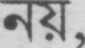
নয়,
